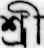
শ্রী
